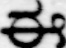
ಈ
